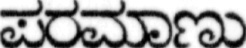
ಪರಮಾಣು
